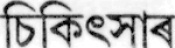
চিকিৎসাৰ
